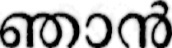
ഞാന്‍
